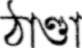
ঠাণ্ডা
